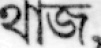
থাজ,
